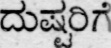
ದುಷ್ಟರಿಗೆ
